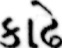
કાઢે
